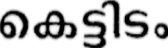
കെട്ടിടം
